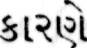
કારણે
